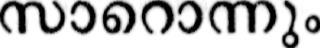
സാറൊന്നും
